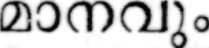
മാനവും
